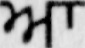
ਆ
